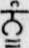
ਨੂੰ
